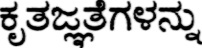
ಕೃತಜ್ಞತೆಗಳನ್ನು
